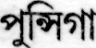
পুন্সিগা
